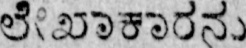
ಲೇಖಾಕಾರನು
